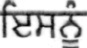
ਇਸਨੂੰ
